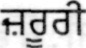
ਜ਼ਰੂਰੀ
